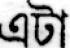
এটা
